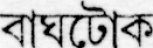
বাঘটোক
